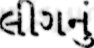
લીગનું
